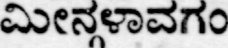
ಮೀನ್ಗಳಾವಗಂ
